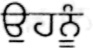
ਉਹਨੂੰ
